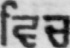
ਵਿਚ
